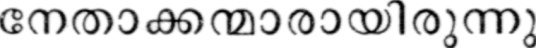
നേതാക്കന്മാരായിരുന്നു
